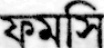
ফমসি
